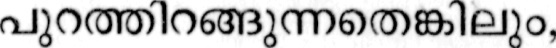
പുറത്തിറങ്ങുന്നതെങ്കിലും,
